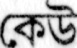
কেউ
